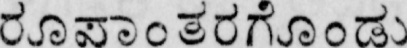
ರೂಪಾಂತರಗೊಂಡು
